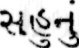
સહુનું
